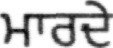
ਮਾਰਦੇ
